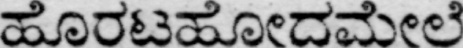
ಹೊರಟಹೋದಮೇಲೆ
